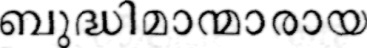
ബുദ്ധിമാന്മാരായ
